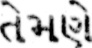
તેમણે
